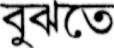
বুঝতে
